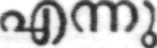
എന്നു
